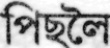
পিছলৈ
